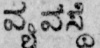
ವ್ಯವಸ್ಥೆ
